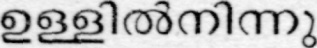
ഉള്ളില്‍നിന്നു
